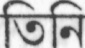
তিনি
